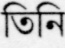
তিনি
